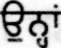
ਉਨ੍ਹਾਂ
